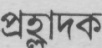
প্ৰহ্লাদক
